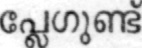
പ്ലേഗുണ്ട്
